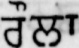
ਰੌਲਾ
